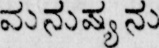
ಮನುಷ್ಯನು
